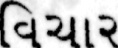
વિચાર
